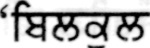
'ਬਿਲਕੁਲ
